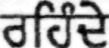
ਰਹਿੰਦੇ
